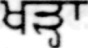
ਖੜ੍ਹਾ
